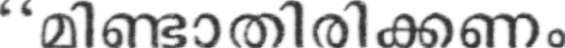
"മിണ്ടാതിരിക്കണം
